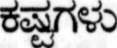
ಕಷ್ಟಗಳು
